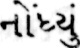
નોંધ્યું
